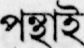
পন্থাই
